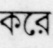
করে
